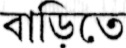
বাড়িতে
